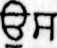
ਉਸ
